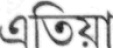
এতিয়া
